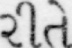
રીતે
